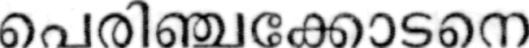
പെരിഞ്ചക്കോടനെ
